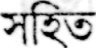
সহিত
